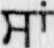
ਸਾਂ
